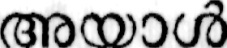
അയാള്‍
